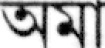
অমা
